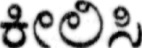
ಕೀಲಿಸಿ
